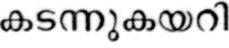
കടന്നുകയറി
